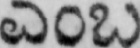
ಎಂಬ
